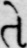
તે
